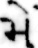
મેં
